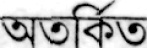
অতর্কিত
